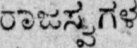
ರಾಜಸ್ವಗಳ
